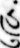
હું
